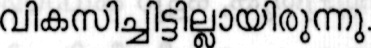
വികസിച്ചിട്ടില്ലായിരുന്നു.
